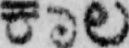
ಕಾಲ
